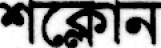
শক্লোন
